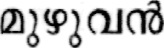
മുഴുവന്‍
